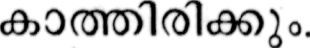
കാത്തിരിക്കും.
